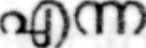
എന്ന
